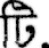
টি.
